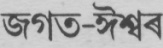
জগত-ঈশ্বৰ
